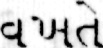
વખતે
